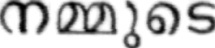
നമ്മുടെ
